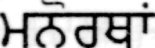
ਮਨੋਰਥਾਂ
